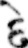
દે
